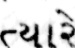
ત્યારે
